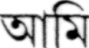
আমি
